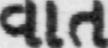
વાત
